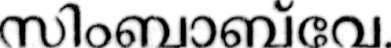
സിംബാബ്വേ.
